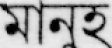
মানুহ
